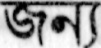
জন্য
